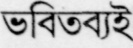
ভবিতব্যই
